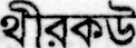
থীরকউ
